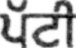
ਪੱਟੀ
